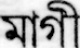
মাগী
